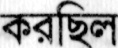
করছিল
